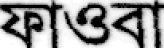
ফাওবা
